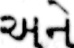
અને
